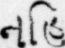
નહિ
